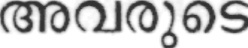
അവരുടെ
